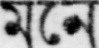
মনে
